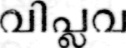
വിപ്ലവ
